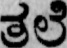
ತಲೆ
